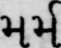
મર્મ
